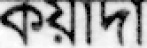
কয়াদা
